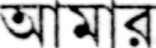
আমার
